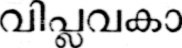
വിപ്ലവകാ
